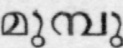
മുമ്പു
